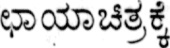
ಛಾಯಾಚಿತ್ರಕ್ಕೆ
